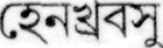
হেনখ্রবসু
